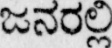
ಜನರಲ್ಲಿ
